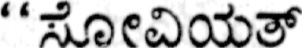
"ಸೋವಿಯತ್
